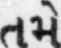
તમે
